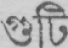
গুটি
